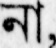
না,
